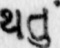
થતું
